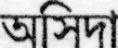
অসিদা
